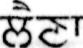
ਲੈਣਾ
